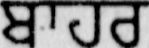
ਬਾਹਰ
